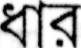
ধার
